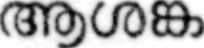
ആശങ്ക
